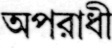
অপরাধী
